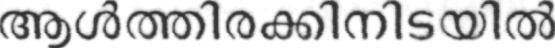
ആള്‍ത്തിരക്കിനിടയില്‍
